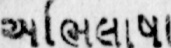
અભિલાષા
